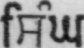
ਸਿੰਘ
